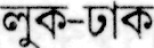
লুক-ঢাক
